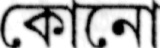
কোনো
